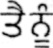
ਤੈਨੂੰ
